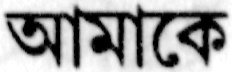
আমাকে
